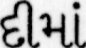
દીમાં
